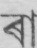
ৰা
